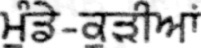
ਮੁੰਡੇ-ਕੁੜੀਆਂ
